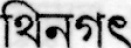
থিংগৎ
